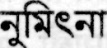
নুমিৎনা
